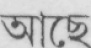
আছে
